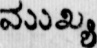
ಮುಖ್ಯ
